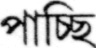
পাচ্ছি
